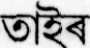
তাইৰ
